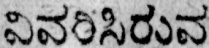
ವಿವರಿಸಿರುವ
